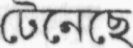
টেনেছে
